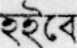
হইবে
